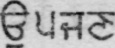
ਉਪਜਣ
